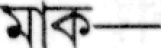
মাক-
